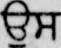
ਉਸ
